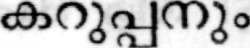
കറുപ്പനും
